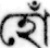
হোঁ
